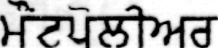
ਮੌਂਟਪੋਲੀਅਰ
